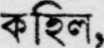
কহিল,
